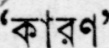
‘কারণ’
